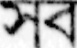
সব
